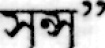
সন্স”
